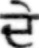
ਦੇ
